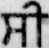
ਸੀ
